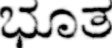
ಭೂತ
